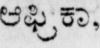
ಆಫ್ರಿಕಾ,
